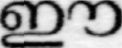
ഈ
